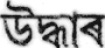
উদ্ধাৰ
